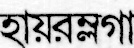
হায়রম্লগা
